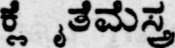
ಕ್ಲೈತೆಮೆಸ್ತ್ರ
